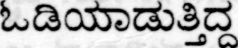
ಓಡಿಯಾಡುತ್ತಿದ್ದ
